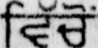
ਵਿੱਚੋਂ
